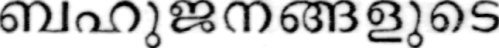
ബഹുജനങ്ങളുടെ
